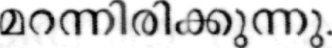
മറന്നിരിക്കുന്നു.
